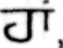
ਹਾਂ,
